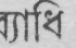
ব্যাধি
